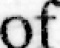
of
